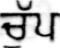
ਚੁੱਪ
